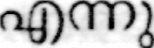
എന്നു
